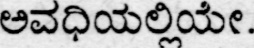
ಅವಧಿಯಲ್ಲಿಯೇ.
